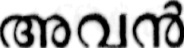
അവന്‍
